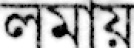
লমায়
